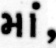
માં,
